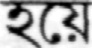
হয়ে
